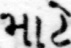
માટે
